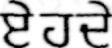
ਏਹਦੇ
